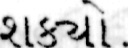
શક્યો.
